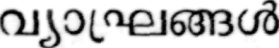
വ്യാഘ്രങ്ങള്‍
